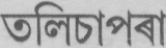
তলিচাপৰা
